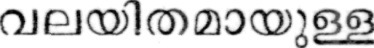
വലയിതമായുള്ള
